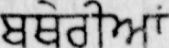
ਬਥੇਰੀਆਂ
